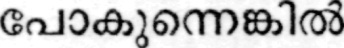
പോകുന്നെങ്കില്‍
